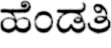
ಹೆಂಡತಿ
